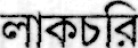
লাকচরি
